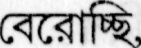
বেরোচ্ছি,
